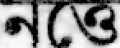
নত্তে
